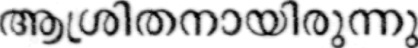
ആശ്രിതനായിരുന്നു
